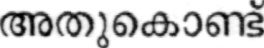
അതുകൊണ്ട്
